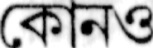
কোনও
